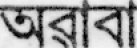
অৱাবা
